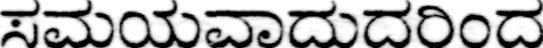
ಸಮಯವಾದುದರಿಂದ
